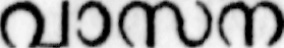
വാസന
